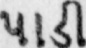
પાડી
